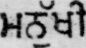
ਮਨੁੱਖੀ
